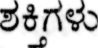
ಶಕ್ತಿಗಳು
